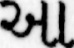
આ
